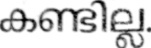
കണ്ടില്ല.
